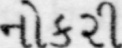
નોકરી
